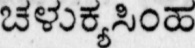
ಚಳುಕ್ಯಸಿಂಹ
